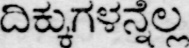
ದಿಕ್ಕುಗಳನ್ನೆಲ್ಲ
